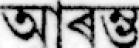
আৰম্ভ
